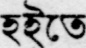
হইতে
